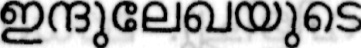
ഇന്ദുലേഖയുടെ
